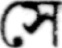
সে
